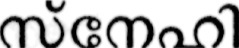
സ്നേഹി
